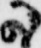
જે
